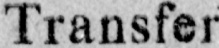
Transfer
